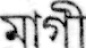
মাগী
